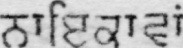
ਨਾਇਕਾਵਾਂ
